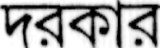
দরকার
